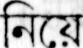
নিয়ে
